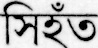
সিহঁত
